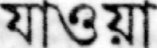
যাওয়া
